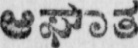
ಆಘಾತ
